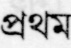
প্রথম
